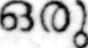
ഒരു
